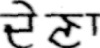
ਦੇਣਾ
